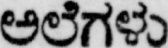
ಅಲೆಗಳು
